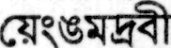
য়েংঙমদ্রবী
